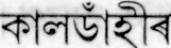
কালডাঁহীৰ
